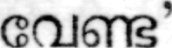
വേണ്ട’
